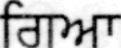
ਗਿਆ
